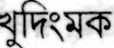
খুদিংমক
